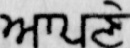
ਆਪਣੇ
